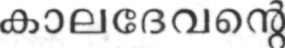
കാലദേവന്റെ
